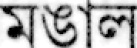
মঙাল
